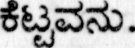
ಕೆಟ್ಟವನು.
